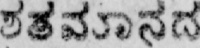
ಶತಮಾನದ
